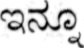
ಇನ್ನೂ
